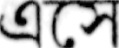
এসে
